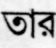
তার
